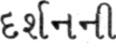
દર્શનની
